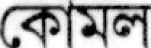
কোমল
